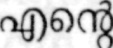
എന്റെ
